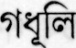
গধূলি
